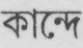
কান্দে
